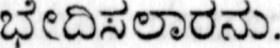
ಭೇದಿಸಲಾರನು.
